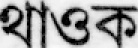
থাওক
